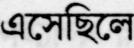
এসেছিলে
